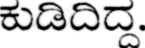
ಕುಡಿದಿದ್ದ.
